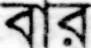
বার
